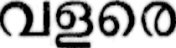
വളരെ
